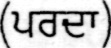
(ਪਰਦਾ)
